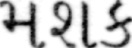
મશક
